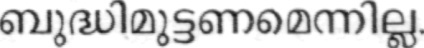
ബുദ്ധിമുട്ടണമെന്നില്ല.
